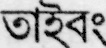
তাইবং
